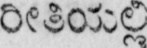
ರೀತಿಯಲ್ಲಿ
